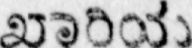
ಖಾರಿಯ
